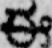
ಈ
